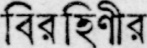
বিরহিণীর
